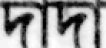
দাদা
